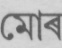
মোৰ
